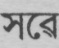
সৱে
